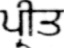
ਪ੍ਰੀਤ
